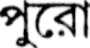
পুরো
